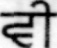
ਵੀ
